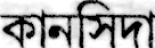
কানসিদা
